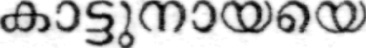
കാട്ടുനായയെ
